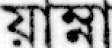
য়াম্না
